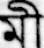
মী
